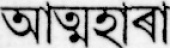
আত্মহাৰা
